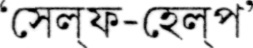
‘সেল্ফ-হেল্প’
